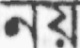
নয়
